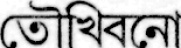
তৌখিবনো
